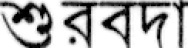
শুরবদা
